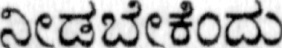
ನೀಡಬೇಕೆಂದು
